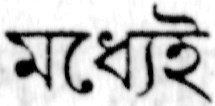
মধ্যেই
